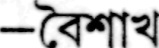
–বৈশাখ
